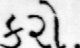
કરો.
